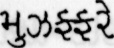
મુઝફ્ફરે
